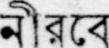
নীরবে
